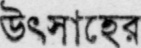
উৎসাহের
